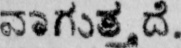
ವಾಗುತ್ತದೆ.
